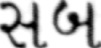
સબ
